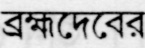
ব্রহ্মদেবের
